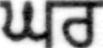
ਘਰ
